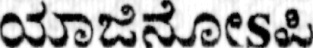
ಯಾಜಿನೋsಪಿ
